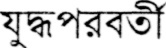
যুদ্ধপরবর্তী
